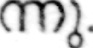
ന്നു.
